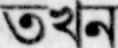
তখন
